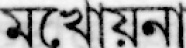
মখোয়না
